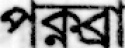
পক্নব্রা
